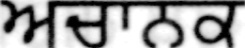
ਅਚਾਨਕ
